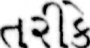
તરીકે
